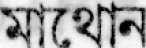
মাথোন
